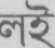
লই
